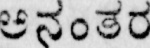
ಅನಂತರ
